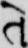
તે
